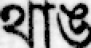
থাঙ
